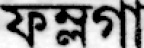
ফম্লগা
